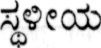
ಸ್ಥಳೀಯ
